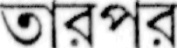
তারপর
